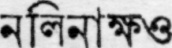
নলিনাক্ষও
